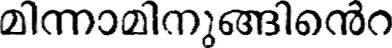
മിന്നാമിനുങ്ങിന്റെ
